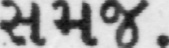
સમજ.
